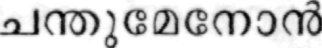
ചന്തുമേനോന്‍
